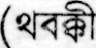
(থবক্কী
